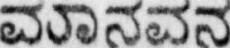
ಮಾನವನ
